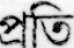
প্রতি
